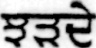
ਝੜਦੇ
